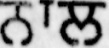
ਨਾਲ
